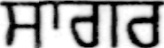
ਸਾਗਰ
